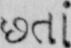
છતાં
